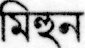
মিহুন
